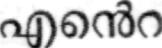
എന്റെ
